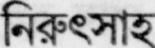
নিরুৎসাহ
